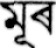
মূৰ
